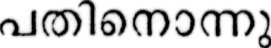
പതിനൊന്നു
